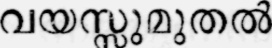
വയസ്സുമുതല്‍
